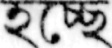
হচ্ছে
